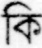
কি
